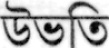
উভতি
